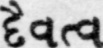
દૈવત્વ
